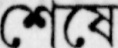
শেষে
